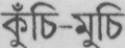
কুঁচি-মুচি
